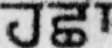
ਹਛਾ
